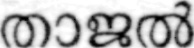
താജല്‍
